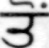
ਤੋਂ
